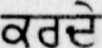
ਕਰਦੇ
